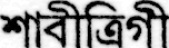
শাবীত্রিগী
